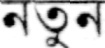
নতুন
